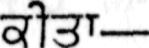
ਕੀਤਾ-
